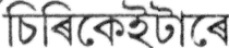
চিৰিকেইটাৰে
